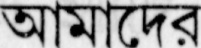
আমাদের
